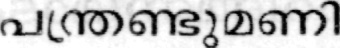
പന്ത്രണ്ടുമണി
